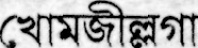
খোমজীল্লগা
